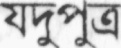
যদুপুত্র
